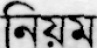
নিয়ম
